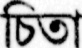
চিতা
